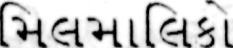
મિલમાલિકો
